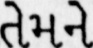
તેમને
